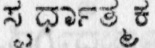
ಸ್ಪರ್ಧಾತ್ಮಕ
